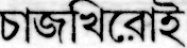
চাজখিরোই
